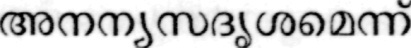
അനന്യസദൃശമെന്ന്
